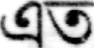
এত
